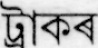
ট্রাকৰ
